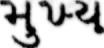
મુખ્ય
